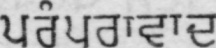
ਪਰੰਪਰਾਵਾਦ
